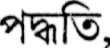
পদ্ধতি,
